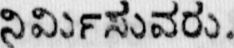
ನಿರ್ಮಿಸುವರು.
